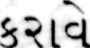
કરાવે
